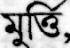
মুর্ত্তি,
